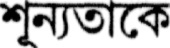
শূন্যতাকে
